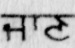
ਜਾਣ
